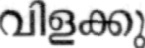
വിളക്കു
